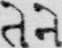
તેને
